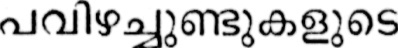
പവിഴച്ചുണ്ടുകളുടെ
